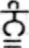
ਨੂੰ
